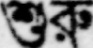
শুরু
